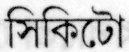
সিকিটো
